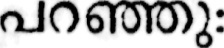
പറഞ്ഞു:
